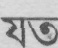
যত
